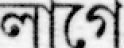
লাগে
